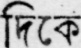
দিকে
